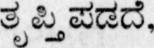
ತೃಪ್ತಿಪಡದೆ,
